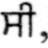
ਸੀ,
